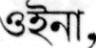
ওইনা,
